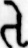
તે
